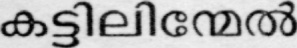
കട്ടിലിന്മേല്‍
